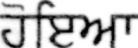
ਹੋਇਆ
